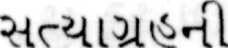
સત્યાગ્રહની
